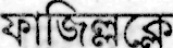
ফাজিল্লক্লে
